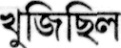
খুজিছিল
